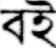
বই
